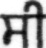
ਸੀ
